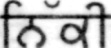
ਨਿੱਕੀ
